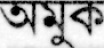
অমুক
